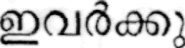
ഇവര്‍ക്കു
